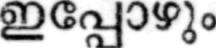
ഇപ്പോഴും
